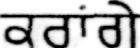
ਕਰਾਂਗੇ
